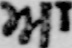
ਆ
